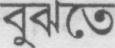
বুঝতে
